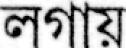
লগায়
